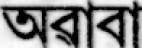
অৱাবা
